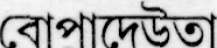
বোপাদেউতা
